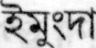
ইমুংদা
